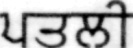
ਪਤਲੀ
